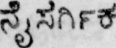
ನೈಸರ್ಗಿಕ
